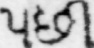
પછી
